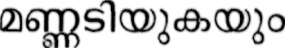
മണ്ണടിയുകയും
